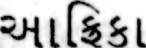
આફ્રિકા
